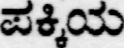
ಪಕ್ಕಿಯ
